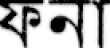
ফনা
